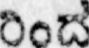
ರಿಂದ
